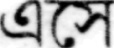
এসে
